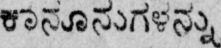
ಕಾನೂನುಗಳನ್ನು
